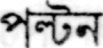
পল্টন
